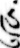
હું
